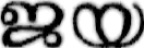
ജയ
